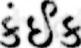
કંઈક
